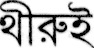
থীরুই
